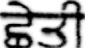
ਛੇਤੀ
